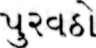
પુરવઠો
